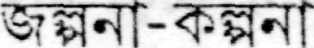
জল্পনা-কল্পনা
